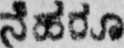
ನೆಹರೂ
